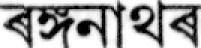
ৰঙ্গনাথৰ
